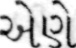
એણે
